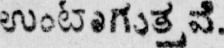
ಉಂಟಾಗುತ್ತವೆ.
